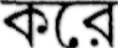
করে
